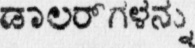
ಡಾಲರ್‌ಗಳನ್ನು
